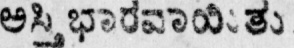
ಅಸ್ತಿಭಾರವಾಯಿತು
